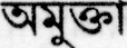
অমুক্তা
